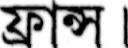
ফ্রান্স।
